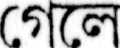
গেলে
